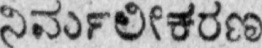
ನಿರ್ಮಲೀಕರಣ
